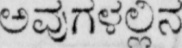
ಅವುಗಳಲ್ಲಿನ
